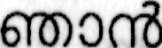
ഞാന്‍
